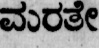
ಮರತೇ
